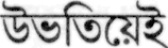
উভতিয়েই
